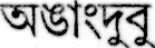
অঙাংদুবু
